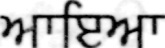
ਆਇਆ
